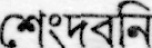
শেংদবনি
